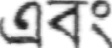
এবং
